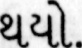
થયો.
